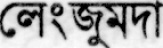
লেংজুমদা
